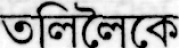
তলিলৈকে
